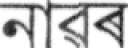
নাৱৰ
